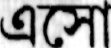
এসো
